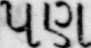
પણ
